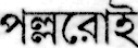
পল্লরোই
